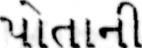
પોતાની
